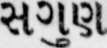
સગુણ
